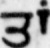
ਤਾਂ
